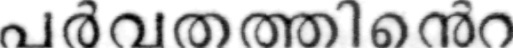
പര്‍വതത്തിന്റെ
